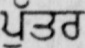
ਪੁੱਤਰ
